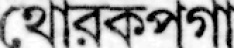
থোরকপগা
